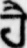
ਹੈ
